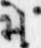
મેં
